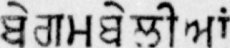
ਬੇਗਮਬੇਲੀਆਂ
